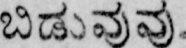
ಬಿಡುವುವು.
